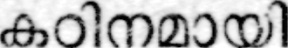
കഠിനമായി
